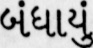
બંધાયું
